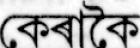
কেৰাকৈ
